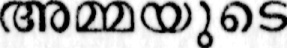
അമ്മയുടെ
